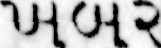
ખબર
